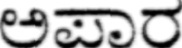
ಅಪಾರ
